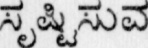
ಸೃಷ್ಟಿಸುವ
